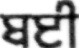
ਬਈ
